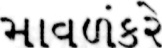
માવળંકરે
